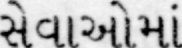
સેવાઓમાં
